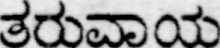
ತರುವಾಯ
